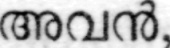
അവന്‍,
